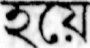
হয়ে
